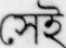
সেই
